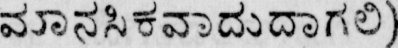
ಮಾನಸಿಕವಾದುದಾಗಲಿ)
